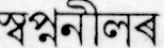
স্বপ্ননীলৰ
